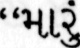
"મારું
